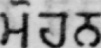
ਮੋਹਨ
